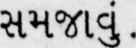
સમજાવું.
